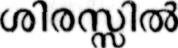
ശിരസ്സില്‍
